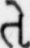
તે
